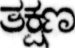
ತಕ್ಷಣ
